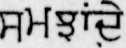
ਸਮਝਾਂਦੇ
